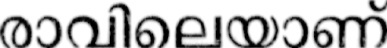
രാവിലെയാണ്
